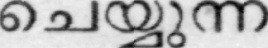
ചെയ്യുന്ന
